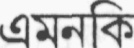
এমনকি
